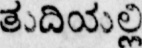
ತುದಿಯಲ್ಲಿ
